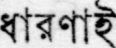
ধারণাই
